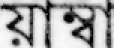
য়াম্বা
